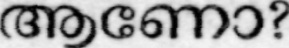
ആണോ?
